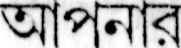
আপনার
